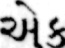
એક
